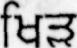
ਖਿੜ
